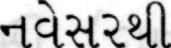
નવેસરથી
